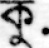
কু.
